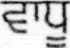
ਵਾਧੂ
